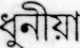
ধুনীয়া
